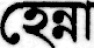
হেন্না
